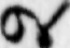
જ
